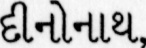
દીનોનાથ,
